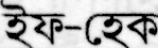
ইফ-হেক
